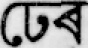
ঢেৰ
